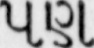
પણ
